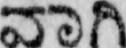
ವಾಗಿ
